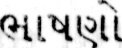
ભાષણો
